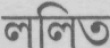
ললিত
